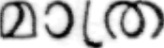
മാത്ര
